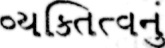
વ્યક્તિત્વનું
